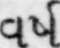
વર્ષ
